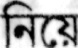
নিয়ে
